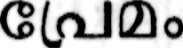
പ്രേമം
